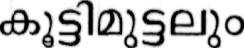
കൂട്ടിമുട്ടലും
